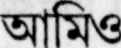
আমিও
